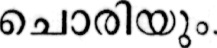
ചൊരിയും.
